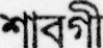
শাবগী
